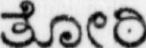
ತೋರಿ
